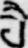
ਹੈ
